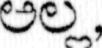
ಅಲ್ಲ,
